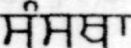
ਸੰਸਥਾ
